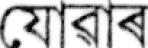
যোৱাৰ
